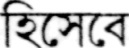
হিসেবে
